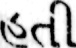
હતી
